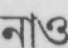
নাও
